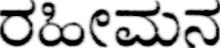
ರಹೀಮನ
